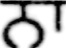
ਨਾ
